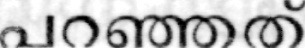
പറഞ്ഞത്
